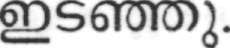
ഇടഞ്ഞു.
